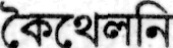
কৈথেলনি
